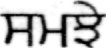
ਸਮਝੇ
